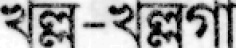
খল্ল-খল্লগা
